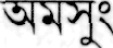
অমসুং
